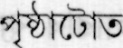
পৃষ্ঠাটোত
